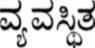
ವ್ಯವಸ್ಥಿತ
